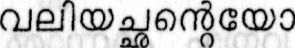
വലിയച്ഛന്റെയോ
